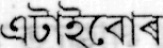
এটাইবোৰ
